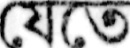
যেতে
